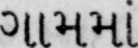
ગામમાં
